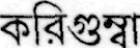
করিগুম্বা
